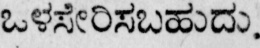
ಒಳಸೇರಿಸಬಹುದು.
